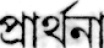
প্রার্থনা
